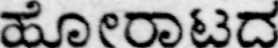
ಹೋರಾಟದ
